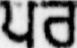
ਪਰ
